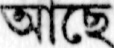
আছে
